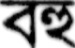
বহু
